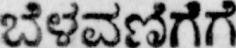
ಬೆಳವಣಿಗೆಗೆ
